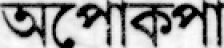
অপোকপা
